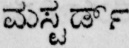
ಮಸ್ಟರ್ಡ್
